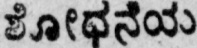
ಶೋಧನೆಯ
